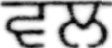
ਵਲ
